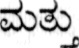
ಮತ್ತು
